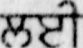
ਲਈ
